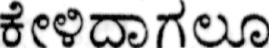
ಕೇಳಿದಾಗಲೂ
